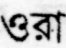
ওরা
